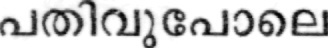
പതിവുപോലെ
